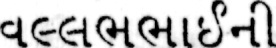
વલ્લભભાઈની
